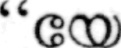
"യേ
